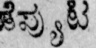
ಡೆಪ್ಯುಟಿ
